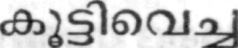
കൂട്ടിവെച്ച
